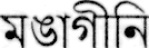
মঙাগীনি
